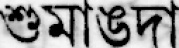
শুমাঙদা
